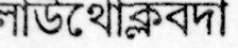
লাউথোক্লবদা
